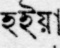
হইয়া
